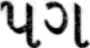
પગ
